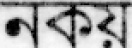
নকয়
